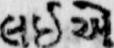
લઈએ
